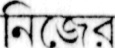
নিজের
